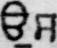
ਉਸ
